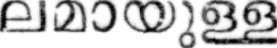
ലമായുള്ള
